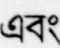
এবং
